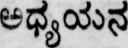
ಅಧ್ಯಯನ
